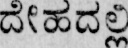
ದೇಹದಲ್ಲಿ
